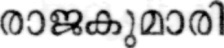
രാജകുമാരി
